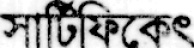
সার্টিফিকেৎ
